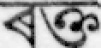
ৰক্ত
